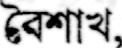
বৈশাখ,
